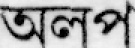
অলপ
